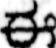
ಈ
